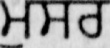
ਮੁਸਰ
